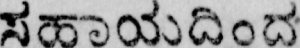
ಸಹಾಯದಿಂದ
